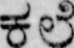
ಕಲೆ
